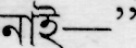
নাই-"
